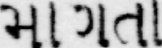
માગતા
